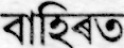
বাহিৰত
